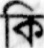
কি
